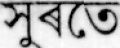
সুৰতে
